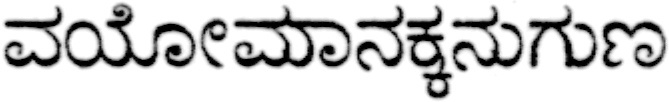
ವಯೋಮಾನಕ್ಕನುಗುಣ
